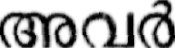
അവര്‍
